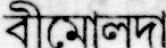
বীমোলদা
